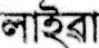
লাইৱা
